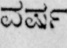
ವರ್ಷ
